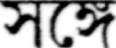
সঙ্গে
